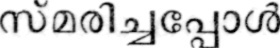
സ്മരിച്ചപ്പോള്‍
